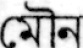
মৌন
